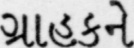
ગ્રાહકને
